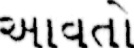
આવતો
